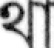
থা
